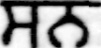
ਸਨ
